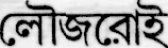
লৌজরোই
